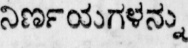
ನಿರ್ಣಯಗಳನ್ನು
